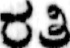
ರತಿ
